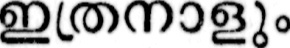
ഇത്രനാളും
